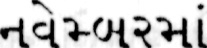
નવેમ્બરમાં
